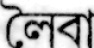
লৈবা
